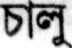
চালু
